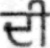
ਦੀ
